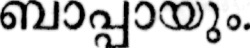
ബാപ്പായും.
